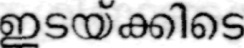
ഇടയ്ക്കിടെ
